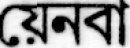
য়েনবা
